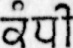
ਕੰਧੀ
